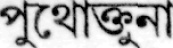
পুথোক্তুনা
